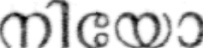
നിയോ
